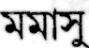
মমাসু
